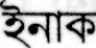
ইনাক
